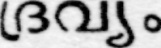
ദ്രവ്യം
